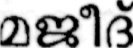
മജീദ്
